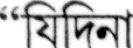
"যিদিনা
